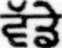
ਵੱਡੇ
